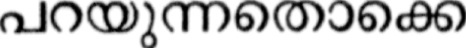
പറയുന്നതൊക്കെ
